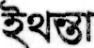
ইথন্তা
